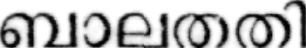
ബാലതതി
